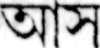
আস
